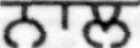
ਨਾਲ
